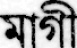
মাগী
